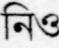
নিও
